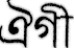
ঐগী
